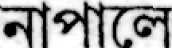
নাপালে
